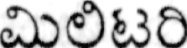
ಮಿಲಿಟರಿ
